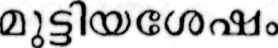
മുട്ടിയശേഷം
